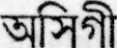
অসিগী
